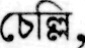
চেল্লি,
